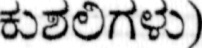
ಕುಶಲಿಗಳು)
